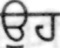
ਉਹ
